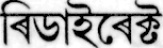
ৰিডাইৰেক্ট
